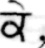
ਕੇ,
